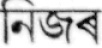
নিজৰ
